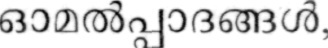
ഓമല്‍പ്പാദങ്ങള്‍,
